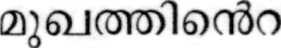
മുഖത്തിന്റെ
